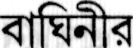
বাঘিনীর
